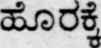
ಹೊರಕ್ಕೆ
